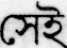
সেই
